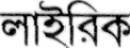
লাইরিক
